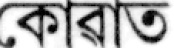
কোৱাত
